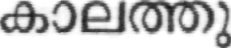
കാലത്തു
